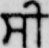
ਸੀ
